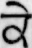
ਕੇ
